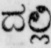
ದಲ್ಲಿ
